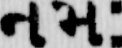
નમઃ
